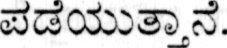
ಪಡೆಯುತ್ತಾನೆ.
